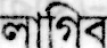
লাগিব
